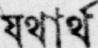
যথার্থ
